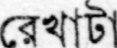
রেখাটা
